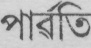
পাৰ্ৱতি
